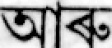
আৰু
